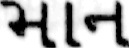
માન
